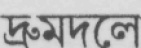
দ্ৰুমদলে
